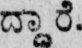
ದ್ದಾರೆ.
